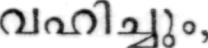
വഹിച്ചും,
